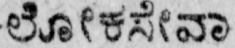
ಲೋಕಸೇವಾ
